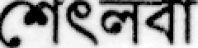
শেৎলবা
